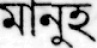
মানুহ
